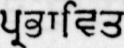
ਪ੍ਰਭਾਵਿਤ
